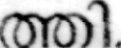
ത്തി.
